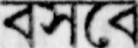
বসবে
